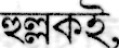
হুল্লকই,
